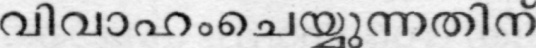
വിവാഹംചെയ്യുന്നതിന്
